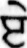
ਏ
